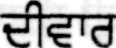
ਦੀਵਾਰ
